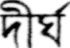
দীর্ঘ
